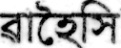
ৱাহৈসি
